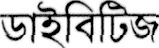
ডাইবিটিজ
